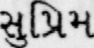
સુપ્રિમ
